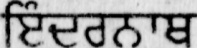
ਇੰਦਰਨਾਥ
